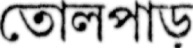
তোলপাড়
